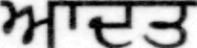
ਆਦਤ
